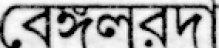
বেঙ্গলরদা
